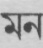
মন
